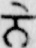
ਨੇ
